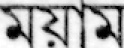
ময়াম
